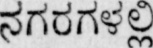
ನಗರಗಳಲ್ಲಿ
